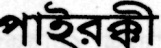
পাইরক্কী
